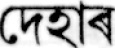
দেহাৰ
